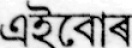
এইবোৰ
